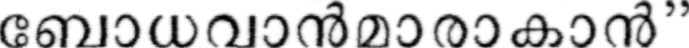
ബോധവാന്‍മാരാകാന്‍"
